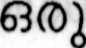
ഒരു
